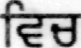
ਵਿਚ
